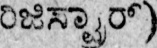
ರಿಜಿಸ್ಟ್ರಾರ್)
